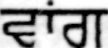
ਵਾਂਗ
